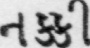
નક્કી
